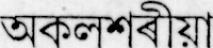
অকলশৰীয়া
